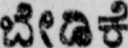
ಬೇಡಿಕೆ
